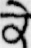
ਕੇ
